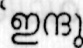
'ഇന്ദു
